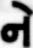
ને
